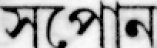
সপোন
